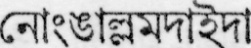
নোংঙাল্লমদাইদা
